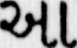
આ
